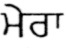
ਮੇਰਾ
